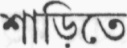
শাড়িতে
